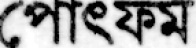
পোৎফম
